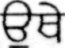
ਉਥੇ
